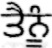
ਤੈਨੂੰ
